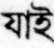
যাই
